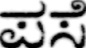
ಪಸೆ
